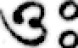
ওঃ
